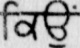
ਕਿਉਂ
